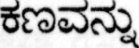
ಕಣವನ್ನು
